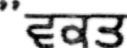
''ਵਕਤ
